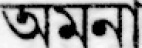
অমনা
